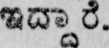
ಇದ್ದಾರೆ.
